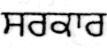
ਸਰਕਾਰ
